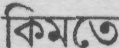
কিমতে
